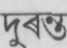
দুৰন্ত
